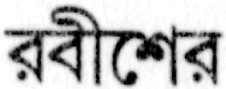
রবীশের
